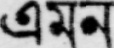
এমন
